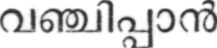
വഞ്ചിപ്പാന്‍
